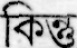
কিন্তু
